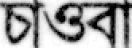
চাওবা
